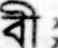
বীঃ
